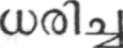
ധരിച്ച
